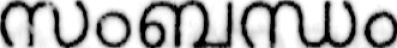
സംബന്ധം
